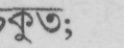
চকুত;
